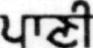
ਪਾਣੀ
